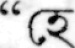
"হে
